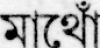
মাথোঁ
